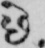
છે.
